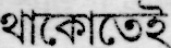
থাকোতেই
